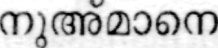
നുഅമാനെ
